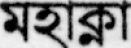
মহাক্না
